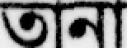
তানা
